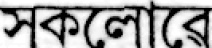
সকলোৱে
